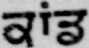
ਕਾਂਡ
